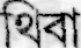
থিবা
